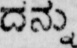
ದನ್ನು
